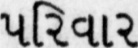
પરિવાર
